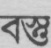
বস্তু
